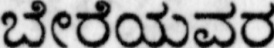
ಬೇರೆಯವರ
